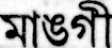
মাঙগী
